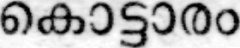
കൊട്ടാരം
